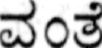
ವಂತೆ
